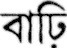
বাঢ়ি
